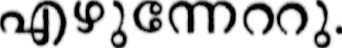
എഴുന്നേററു.
